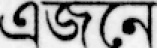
এজনে
